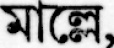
মাল্লে,
